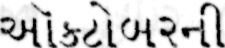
ઑક્ટોબરની
